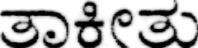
ತಾಕೀತು
